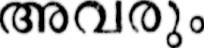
അവരും
